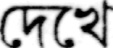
দেখে
